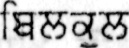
ਬਿਲਕੁਲ
